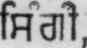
ਸਿੰਗੀ,
